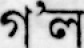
গ'ল
